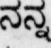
ನನ್ನ
